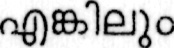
എങ്കിലും
